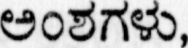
ಅಂಶಗಳು,
